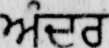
ਅੰਦਰ
